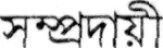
সম্প্রদায়ী
